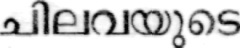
ചിലവയുടെ
